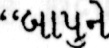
"બાપુને
